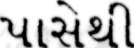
પાસેથી
